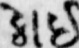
કોઈ
